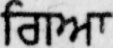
ਗਿਆ
